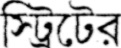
স্ট্রিটের
